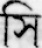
সি
